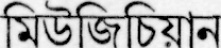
মিউজিচিয়ান
